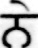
ਨੇ
